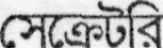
সেক্রেটরি
